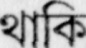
থাকি
